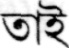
তাই
